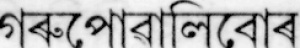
গৰুপোৱালিবোৰ
